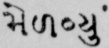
મેળવ્યું
